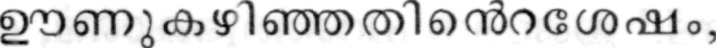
ഊണുകഴിഞ്ഞതിൻെറശേഷംഷം,
